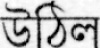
উঠিল
